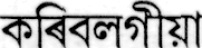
কৰিবলগীয়া
